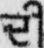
ਦੀ
